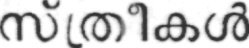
സ്ത്രീകള്‍
